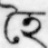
হৈ
